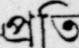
প্রতি
